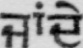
ਜਾਂਦੇ
